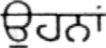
ਉਹਨਾਂ
